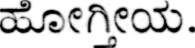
ಹೋಗ್ತೀಯ.
